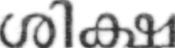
ശിക്ഷ
